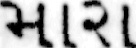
મારા
